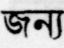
জন্য
